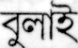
বুলাই
